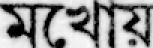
মখোয়
